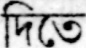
দিতে
